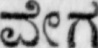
ವೇಗ
